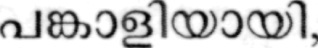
പങ്കാളിയായി,
